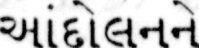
આંદોલનને
